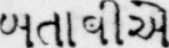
બતાવીએ
